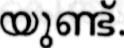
യുണ്ട്.
